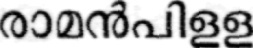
രാമന്‍പിളള
